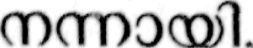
നന്നായി.
